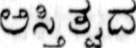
ಅಸ್ತಿತ್ವದ
